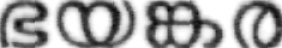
ഭയങ്കര
